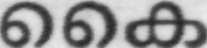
കൈ
